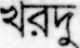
খরদু
